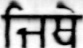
ਜਿਥੇ
